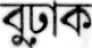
বুঢ়াক
